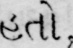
હતો,
